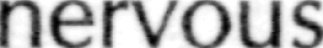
nervous
